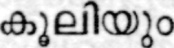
കൂലിയും
